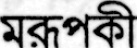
মরূপকী
